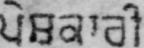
ਪੇਸ਼ਕਾਰੀ
